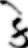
કે
